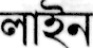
লাইন
